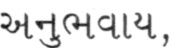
અનુભવાય,
